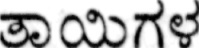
ತಾಯಿಗಳ
